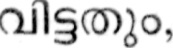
വിട്ടതും,
